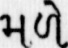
મળે
